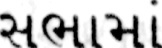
સભામાં
